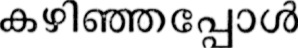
കഴിഞ്ഞപ്പോള്‍
